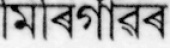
মিৰিগাৱৰ
